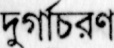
দুর্গাচরণ
